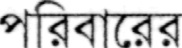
পরিবারের
